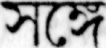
সঙ্গে
